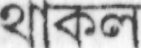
থাকল
